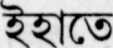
ইহাতে
